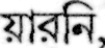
য়ারনি,
